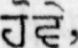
ਹੋਵੇ,
